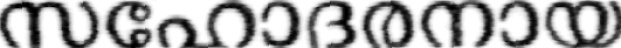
സഹോദരനായ
